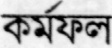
কর্মফল
